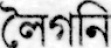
লৈগনি
